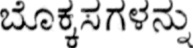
ಬೊಕ್ಕಸಗಳನ್ನು
